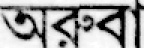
অরুবা
